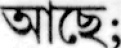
আছে;
